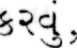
કરવું,
